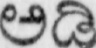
ಅಡಿ
